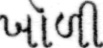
ખૉળી
